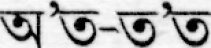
অ'ত-ত'ত
